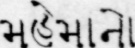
મહેમાનો
